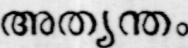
അത്യന്തം
